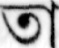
তা
